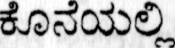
ಕೊನೆಯಲ್ಲಿ
